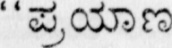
“ಪ್ರಯಾಣ
